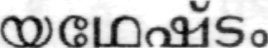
യഥേഷ്ടം
